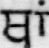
ਥਾਂ
